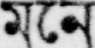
মনে
